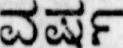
ವರ್ಷ
